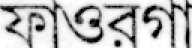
ফাওরগা
